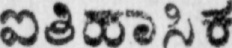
ಐತಿಹಾಸಿಕ
